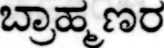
ಬ್ರಾಹ್ಮಣರ
